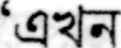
‘এখন
